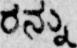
ರನ್ನು
